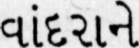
વાંદરાને
